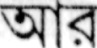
আর
